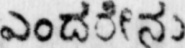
ಎಂದರೇನು
